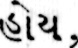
હોય,
